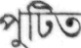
পুটিত
